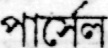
পার্সেল
